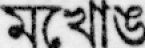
মখোঙ
